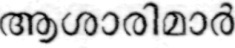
ആശാരിമാര്‍
